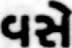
વસે
